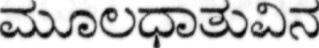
ಮೂಲಧಾತುವಿನ
